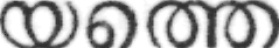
യത്തെ
